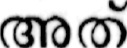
അത്
